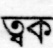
ত্বক
